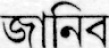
জানিব
